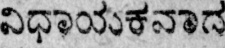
ವಿಧಾಯಕವಾದ
